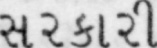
સરકારી
